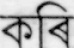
কৰি
